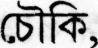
চৌকি,
